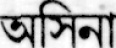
অসিনা
